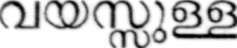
വയസ്സുള്ള
